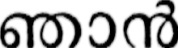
ഞാന്‍
